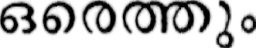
ഒരെത്തും
